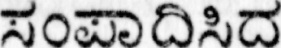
ಸಂಪಾದಿಸಿದ
